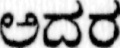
ಅದರ
